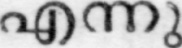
എന്നു
